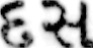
દસ
